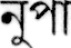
নুপা
